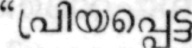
“പ്രിയപ്പെട്ട
